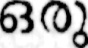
ഒരു
